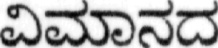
ವಿಮಾನದ
